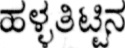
ಹಳ್ಳತಿಟ್ಟಿನ
